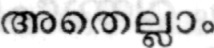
അതെല്ലാം
